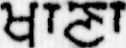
ਖਾਣਾ
